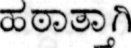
ಹಠಾತ್ತಾಗಿ
